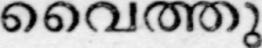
വൈത്തു
